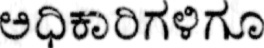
ಅಧಿಕಾರಿಗಳಿಗೂ
